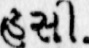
હસી.
